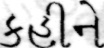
કહીને
